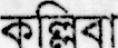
কল্লিবা
